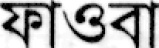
ফাওবা
